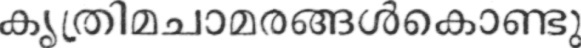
കൃത്രിമചാമരങ്ങള്‍കൊണ്ടു
